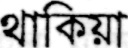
থাকিয়া
